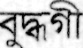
বুদ্ধগী
